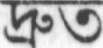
দ্রুত
